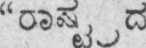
“ರಾಷ್ಟ್ರದ
